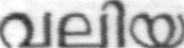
വലിയ
